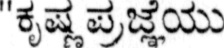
“ಕೃಷ್ಣಪ್ರಜ್ಞೆಯು
